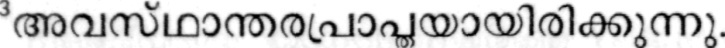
3അവസ്ഥാന്തരപ്രാപ്തയായിരിക്കുന്നു.
